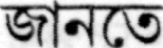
জানতে
